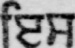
ਇਸ
